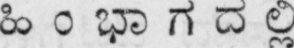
ಹಿಂಭಾಗದಲ್ಲಿ
